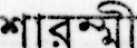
শারম্মী
